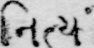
નિત્યં
